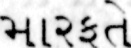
મારફતે
